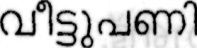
വീട്ടുപണി
